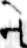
ને
